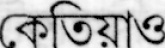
কেতিয়াও
